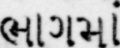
ભાગમાં
